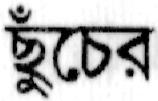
ছুঁচের
